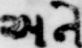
અને
